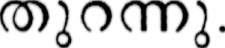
തുറന്നു.
